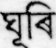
ঘূৰি
